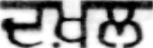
ਦਖ਼ਲ
